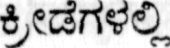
ಕ್ರೀಡೆಗಳಲ್ಲಿ
